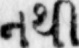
નથી
